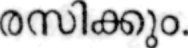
രസിക്കും.
